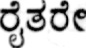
ರೈತರೇ
